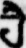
ਹੈ
